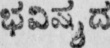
ಭವಿಷ್ಯದ
